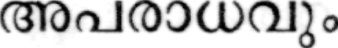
അപരാധവും
